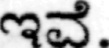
ಇವೆ.
